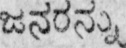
ಜನರನ್ನು
